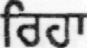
ਰਿਹਾ
